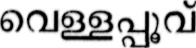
വെള്ളപ്പൂവ്
